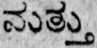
ಮತ್ತು
